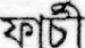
ফাৰ্চী
